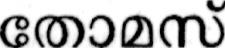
തോമസ്
